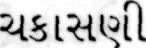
ચકાસણી
